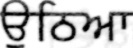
ਉਠਿਆ
